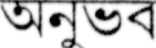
অনুভব
